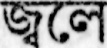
জ্বলে
